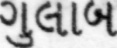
ગુલાબ
